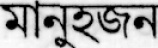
মানুহজন
